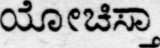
ಯೋಚಿಸ್ತಾ
